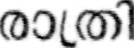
രാത്രി
